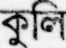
কুলি
